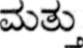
ಮತ್ತು
